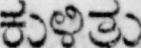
ಕುಳಿತು
